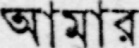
আমার
